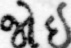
જોઈ
